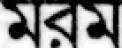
মরম
